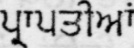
ਪ੍ਰਾਪਤੀਆਂ
